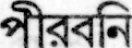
পীরবনি
